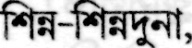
শিন্ন-শিন্নদুনা,
